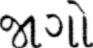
જાગો
